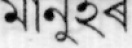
মানুহৰ
